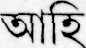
আহি
